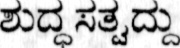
ಶುದ್ಧಸತ್ವದ್ದು
